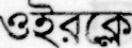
ওইরক্লে
